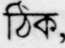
ঠিক,
